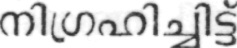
നിഗ്രഹിച്ചിട്ട്
